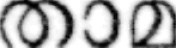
താമ
